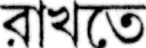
রাখতে
